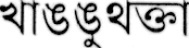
খাঙঙুথক্তা
